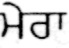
ਮੇਰਾ
